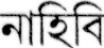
নাহিবি
